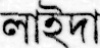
লাইদা
